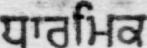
ਧਾਰਮਿਕ
